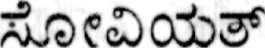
ಸೋವಿಯತ್
